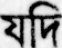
যদি
